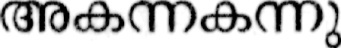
അകന്നകന്നു
